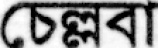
চেল্লবা
